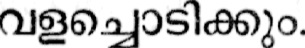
വളച്ചൊടിക്കും.
